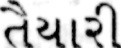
તૈયારી
